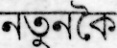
নতুনকৈ
